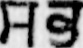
ਸਭ
